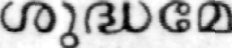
ശുദ്ധമേ
